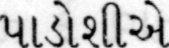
પાડોશીએ
